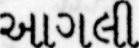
આગલી
